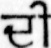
ਦੀ
